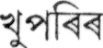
খুপৰিৰ
